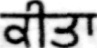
ਕੀਤਾ
